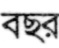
বছর
